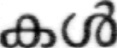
കള്‍
